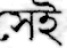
সেই
